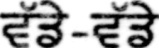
ਵੱਡੇ-ਵੱਡੇ
